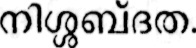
നിശ്ശബ്ദത.
